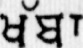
ਖੱਬਾ
